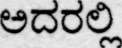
ಅದರಲ್ಲಿ
